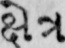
ક્ષેત્ર
